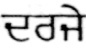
ਦਰਜੇ
